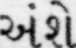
અંશે
